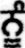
ਨੂੰ
